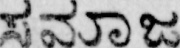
ಸಮಾಜ
